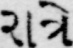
રાત્રે
